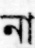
না
